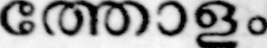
ത്തോളം
